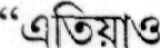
"এতিয়াও
